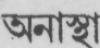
অনাস্থা
